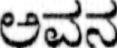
ಅವನ
